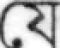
যে
